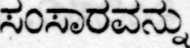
ಸಂಸಾರವನ್ನು
